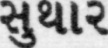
સુથાર
